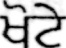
ਖੋਟੇ
